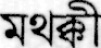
মথক্কী
